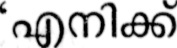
‘എനിക്ക്
